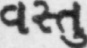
વસ્તુ
